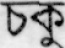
চকু
